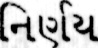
નિર્ણય
